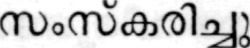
സംസ്കരിച്ചു
